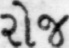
રોજ
